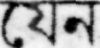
যেন
